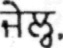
ਜੇਲ੍ਹ,
